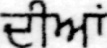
ਦੀਆਂ
